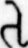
તે
